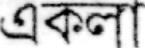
একলা
